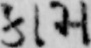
કામ
